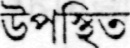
উপস্থিত
